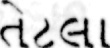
તેટલા
